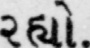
રહ્યો.
